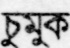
চুমুক
